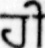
ਹੀ
